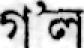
গ'ল
